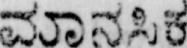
ಮಾನಸಿಕ
